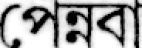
পেন্নবা
